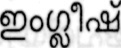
ഇംഗ്ലീഷ്
